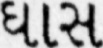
ઘાસ
